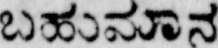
ಬಹುಮಾನ
